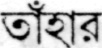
তাঁহার
